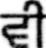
ਵੀ
